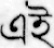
এই
